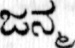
ಜನ್ಮ
